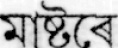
মাষ্টৰে
